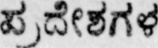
ಪ್ರದೇಶಗಳ
